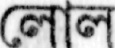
লোল
